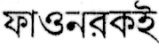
ফাওনরকই
